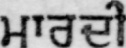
ਮਾਰਦੀ
